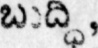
ಬುದ್ಧಿ,
